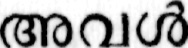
അവള്‍
